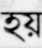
হয়
